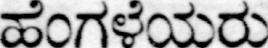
ಹೆಂಗಳೆಯರು
